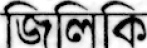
জিলিকি
